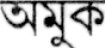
অমুক
